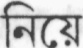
নিয়ে
